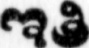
ಇತಿ
